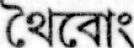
থৈবোং
